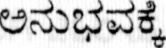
ಅನುಭವಕ್ಕೆ
